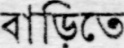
বাড়িতে
